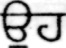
ਉਹ
